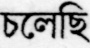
চলেছি
